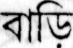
বাড়ি
